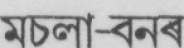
মচলা-বনৰ
